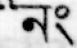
“নং
